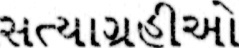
સત્યાગ્રહીઓ
